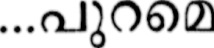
...പുറമെ
